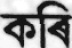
কৰি
